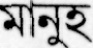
মানুহ
